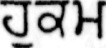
ਹੁਕਮ
